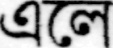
এলে
